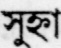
সুহ্না
